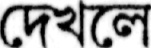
দেখলে
